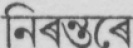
নিৰন্তৰে
